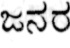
ಜನರ
